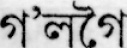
গ'লগৈ
